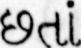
છતાં
